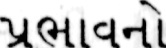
પ્રભાવનો
